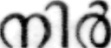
നിര്‍
